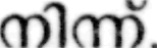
നിന്ന്.
